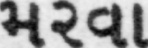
મરવા
